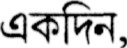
একদিন,
